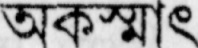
অকস্মাৎ
